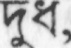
দুধ,
